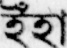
ইঁহা
